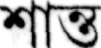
শান্ত
